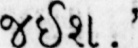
જઈશ.'
